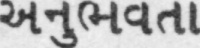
અનુભવતા
